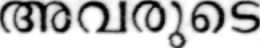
അവരുടെ
